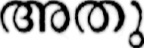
അതു
